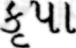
કૃપા
